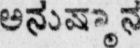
ಅನುಷ್ಠಾನ
